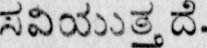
ಸವಿಯುತ್ತದೆ.
